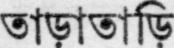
তাড়াতাড়ি
